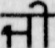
ਜੀ
